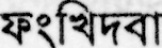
ফংখিদবা
